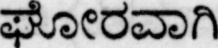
ಘೋರವಾಗಿ
